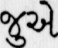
જુએ
